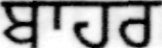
ਬਾਹਰ
